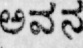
ಅವನ
